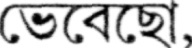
ভেবেছো,
